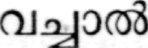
വച്ചാല്‍
